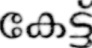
കേട്ട്
